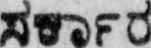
ಸರ್ಕಾರ
